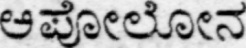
ಅಪೋಲೋನ
